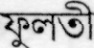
ফুলতী
